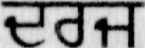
ਦਰਜ
